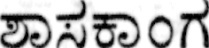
ಶಾಸಕಾಂಗ
